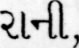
રાની,
